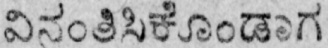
ವಿನಂತಿಸಿಕೊಂಡಾಗ
